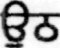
ਉਠ
